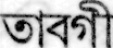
তাবগী
